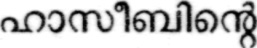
ഹാസീബിന്റെ
